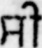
ਸੀ
